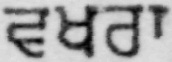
ਵਖਰਾ
